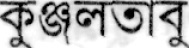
কুঞ্জলতাবু
